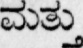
ಮತ್ತು
